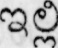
ಇಲ್ಲಿ
